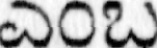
ಎಂಬ
